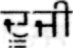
ਦੂਜੀ
